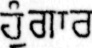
ਹੁੰਗਾਰ
